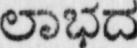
ಲಾಭದ
